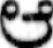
ಆ
